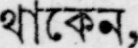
থাকেন,
